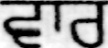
ਵਾਰ
